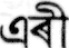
এৰী
